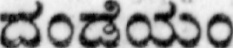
ದಂಡೆಯಂ
